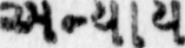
અન્યાય
